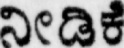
ನೀಡಿಕೆ
